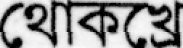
থোকখ্রে
